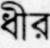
ধীর
